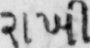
રાખી
